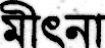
মীৎনা
